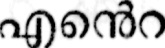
എന്റെ
